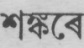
শঙ্কৰে
